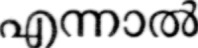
എന്നാല്‍
